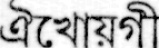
ঐখোয়গী
